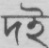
দই
